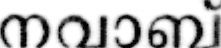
നവാബ്
